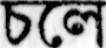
চলে
